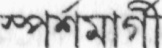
স্পর্শমার্গী
